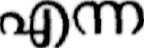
എന്ന
